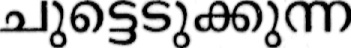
ചുട്ടെടുക്കുന്ന
